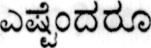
ಎಷ್ಟೆಂದರೂ
